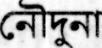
নৌদুনা
